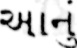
આનું
